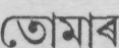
তোমাৰ
